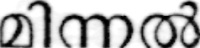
മിന്നല്‍
